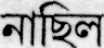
নাছিল
